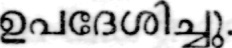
ഉപദേശിച്ചു.
